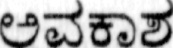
ಅವಕಾಶ
